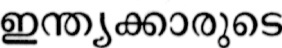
ഇന്ത്യക്കാരുടെ
